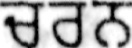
ਚਰਨ
